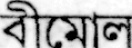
বীমোল
